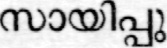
സായിപ്പു
